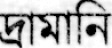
দ্রামানি
